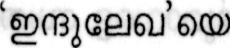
'ഇന്ദുലേഖ'യെ
